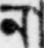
না
